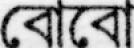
বোবো
